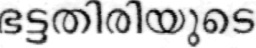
ഭട്ടതിരിയുടെ
